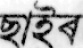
ছাইৰ
